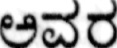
ಅವರ
